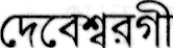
দেবেশ্বরগী
